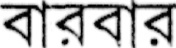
বারবার
